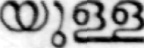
യുള്ള
